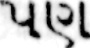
પણ
